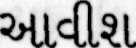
આવીશ
